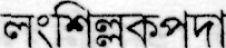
লংশিল্লকপদা
